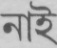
নাই
